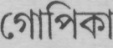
গোপিকা
